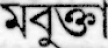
মবুক্তা
